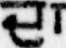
ਦਾ
